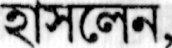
হাসলেন,
